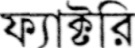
ফ্যাক্টরি
